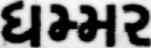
ધમ્મર
